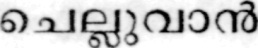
ചെല്ലുവാന്‍
